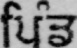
ਪਿੰਡ
